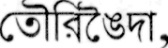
তৌরিঙৈদা,
